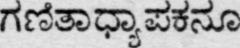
ಗಣಿತಾಧ್ಯಾಪಕನೂ
